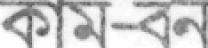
কাম-বন
